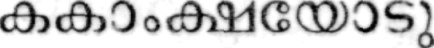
കകാംക്ഷയോടു
